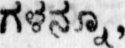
ಗಳನ್ನೂ,
